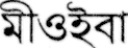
মীওইবা
